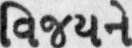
વિજયને
